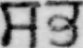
ਸਭ
